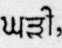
ਘੜੀ,
